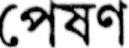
পেষণ
